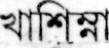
খাশিম্না
